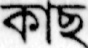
কাছ
